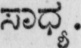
ಸಾಧ್ಯ.
